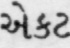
એક્ટ
